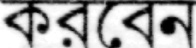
করবেন
